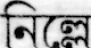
নিল্লে
